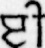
ਈ
